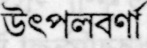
উত্পলবর্ণা
